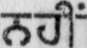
ਨਹੀਂ
